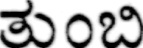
ತುಂಬಿ
